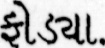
ફોડ્યા.
